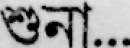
শুনা...
